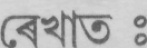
ৰেখাতঃ
